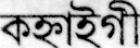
কহ্নাইগী
